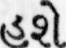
હશે
